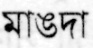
মাঙদা
